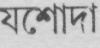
যশোদা
